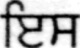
ਇਸ
